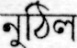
নুঠিল
